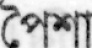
পৈশা
